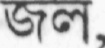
জল,
